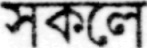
সকলে
